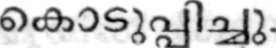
കൊടുപ്പിച്ചു.
